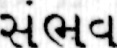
સંભવ
